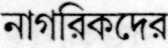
নাগরিকদের
